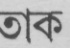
তাক
